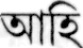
আহি
